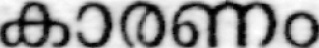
കാരണം
